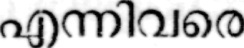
എന്നിവരെ
